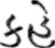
કહે
